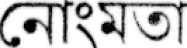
নোংমতা
